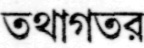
তথাগতর
